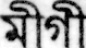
মীগী
